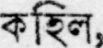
কহিল,
